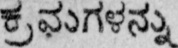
ಕ್ರಮಗಳನ್ನು
